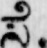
ಸೆ.
